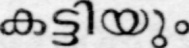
കട്ടിയും
